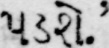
પડશે'.
